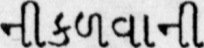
નીકળવાની
